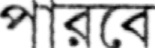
পারবে
